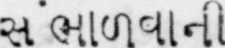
સંભાળવાની
